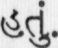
હતું.
